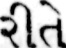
રીતે
